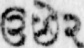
ઉછેર
